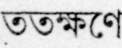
ততক্ষণে
